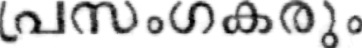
പ്രസംഗകരും
